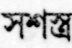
সশস্ত্র
